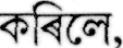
কৰিলে,
